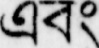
এবং
